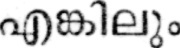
എങ്കിലും
